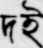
দই
